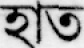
হাত
